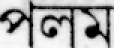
পলম
